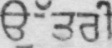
ਉੱਤਰੀ
